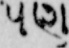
પણ
